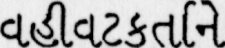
વહીવટકર્તાને
